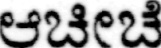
ಆಚೀಚೆ
